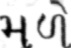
મળે
